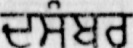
ਦਸੰਬਰ
